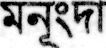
মনূংদা
